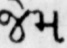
જેમ
